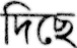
দিছে
